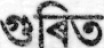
গুৰিত
